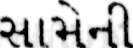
સામેની
